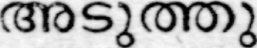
അടുത്തു
